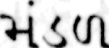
મંડળ
